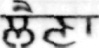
ਲੈਣਾ
